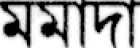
মমাদা
